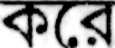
করে
